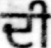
ਦੀ
